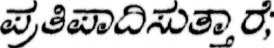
ಪ್ರತಿಪಾದಿಸುತ್ತಾರೆ;
